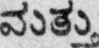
ಮತ್ತು
